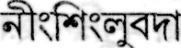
নীংশিংলুবদা
